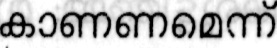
കാണണമെന്ന്
